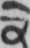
ਕੇ
